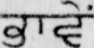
ਭਾਵੇਂ
